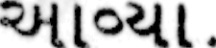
આવ્યા.
